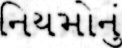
નિયમોનું
